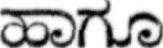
ಹಾಗೂ
